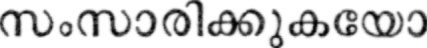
സംസാരിക്കുകയോ
